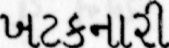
ખટકનારી
